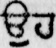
ਉਹ
